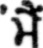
'ਮੈਂ
